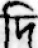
দি
